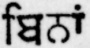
ਬਿਨਾਂ
